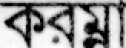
করম্না
